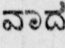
ವಾದ
